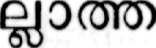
ല്ലാത്ത
